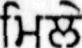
ਮਿਲੇ
